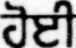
ਹੋਈ
